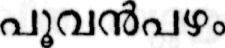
പൂവന്‍പഴം
